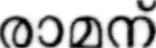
രാമന്
